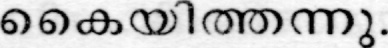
കൈയിത്തന്നു.
